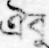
ঐবু
